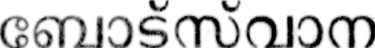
ബോട്സ്വാന
